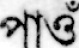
পাওঁ
